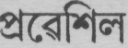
প্ৰৱেশিল
